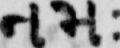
નમઃ
